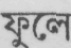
ফুলে
